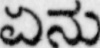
ಏನು
